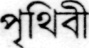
পৃথিবী
